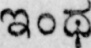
ಇಂಥ
